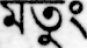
মতুং
